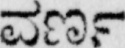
ವರ್ಣ
